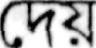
দেয়
